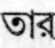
তার
